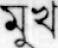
মুখ
